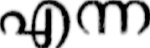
എന്ന
